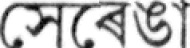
সেৰেঙা
